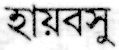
হায়বসু
